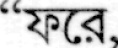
“ফরে,
